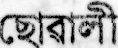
ছোৱালী
